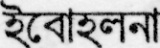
ইবোহলসনা
